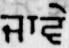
ਜਾਵੇ
